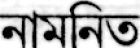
নামনিত
